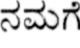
ನಮಗೆ
